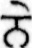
ਨੇ
